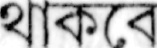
থাকবে
